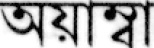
অয়াম্বা
